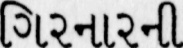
ગિરનારની
